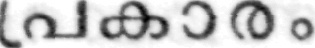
പ്രകാരം
